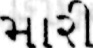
મારી
